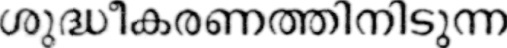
ശുദ്ധീകരണത്തിനിടുന്ന
